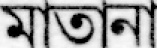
মাতানা
